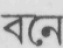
বনে
